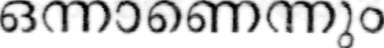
ഒന്നാണെന്നും
